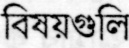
বিষয়গুলি
